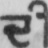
ਦੀ
